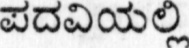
ಪದವಿಯಲ್ಲಿ
